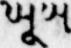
ખૂબ
